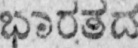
ಭಾರತದ
